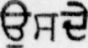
ਉਸਦੇ
